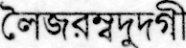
লৈজরম্বদুদগী
